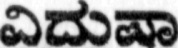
ವಿದುಷಾ
